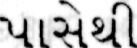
પાસેથી
